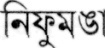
নিফুমঙা
